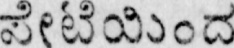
ಪೇಟೆಯಿಂದ
